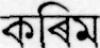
কৰিম
